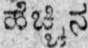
ಹೆಚ್ಚಿನ
